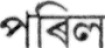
পৰিল
